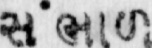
સંભાળ
